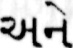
અને
